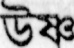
উষ্ণ
